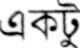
একটু
